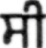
ਸੀ
